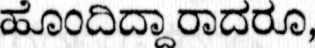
ಹೊಂದಿದ್ದಾರಾದರೂ,
